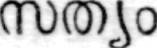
സത്യം
